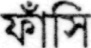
ফাঁসি
